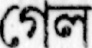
গেল
